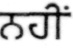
ਨਹੀਂ
